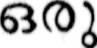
ഒരു
